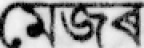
মেজৰ
